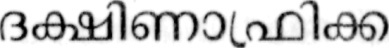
ദക്ഷിണാഫ്രിക്ക
